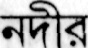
নদীর
